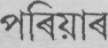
পৰিয়াৰ
